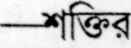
–শক্তির
